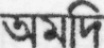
অমদি
